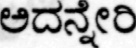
ಅದನ್ನೇರಿ
